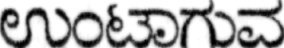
ಉಂಟಾಗುವ
